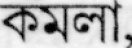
কমলা,
